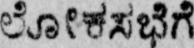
ಲೋಕಸಭೆಗೆ
